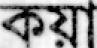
কয়া
